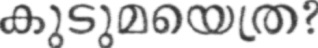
കുടുമയെത്ര?
